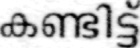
കണ്ടിട്ട്
